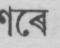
শৰে
